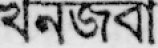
খনজবা
